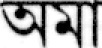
অমা
